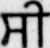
ਸੀ
